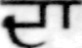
ਦਾ
